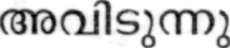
അവിടുന്നു
